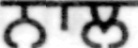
ਨਾਲ
